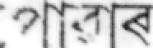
পোৱাৰ
